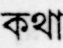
কথা
